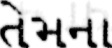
તેમના
